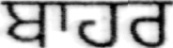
ਬਾਹਰ
